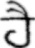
ਹੈ
